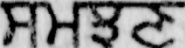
ਸਮਝਣ
